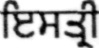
ਇਸਤ੍ਰੀ
